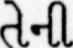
તેની
